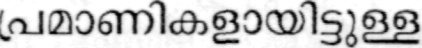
പ്രമാണികളായിട്ടുള്ള
